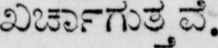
ಖರ್ಚಾಗುತ್ತವೆ.
